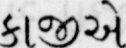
કાજીએ
